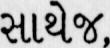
સાથેજ,
